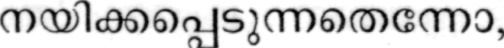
നയിക്കപ്പെടുന്നതെന്നോ,
